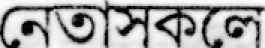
নেতাসকলে
